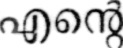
എന്റെ
